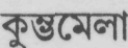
কুম্ভমেলা
